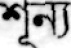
শূন্য
